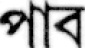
পাব
